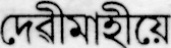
দেৱীমাহীয়ে
